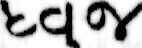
ધ્વજ
